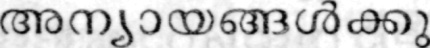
അന്യായങ്ങള്‍ക്കു
